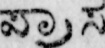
ಪ್ರಾಸ
